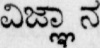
ವಿಜ್ಞಾನ
